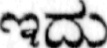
ಇದು
